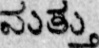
ಮತ್ತು
